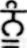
ਨੂੰ
